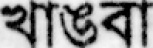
খাঙবা
